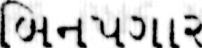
બિનપગાર
